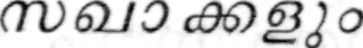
സഖാക്കളും
